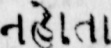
નહોતા
